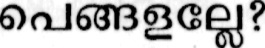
പെങ്ങളല്ലേ?
